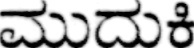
ಮುದುಕಿ
